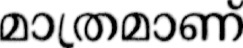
മാത്രമാണ്
